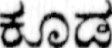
ಕೂಡ
